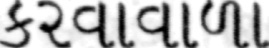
કરવાવાળા
